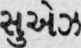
સુએઝ
